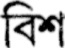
বিশ
